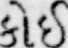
કોઈ
